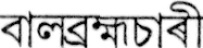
বালব্রহ্মচাৰী
